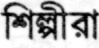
শিল্পীরা
